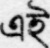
এই
